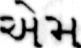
એમ
